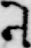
ને
